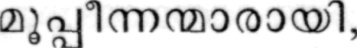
മൂപ്പീന്നന്മാരായി,
